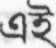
এই
